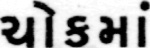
ચોકમાં
